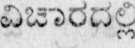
ವಿಚಾರದಲ್ಲಿ
